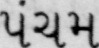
પંચમ
